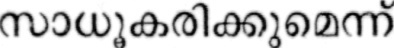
സാധൂകരിക്കുമെന്ന്
